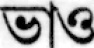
ভাও
